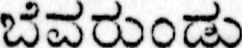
ಬೆವರುಂಡು
